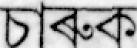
চাৰুক
